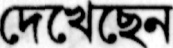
দেখেছেন
